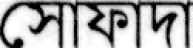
সোফাদা
